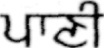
ਪਾਣੀ
